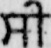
ਸੀ
